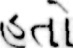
હતો
